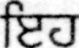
ਇਹ
